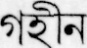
গহীন
